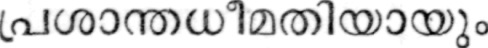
പ്രശാന്തധീമതിയായും
